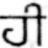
ਹੀ
